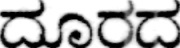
ದೂರದ
